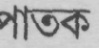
পাতক
